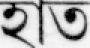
হাত
